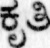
ಕೃತಿ
